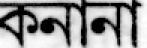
কনানা
